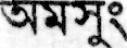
অমসুং
